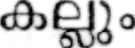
കല്ലും
